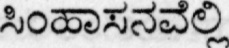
ಸಿಂಹಾಸನವೆಲ್ಲಿ
